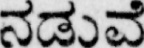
ನಡುವೆ
